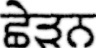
ਛੇੜਨ
